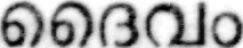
ദൈവം
